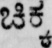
ಚಿಕ್ಕ
